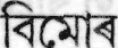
বিমোৰ
